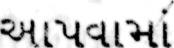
આપવામાં
